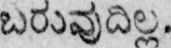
ಬರುವುದಿಲ್ಲ.
